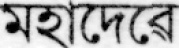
মহাদেৱে
